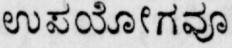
ಉಪಯೋಗವೂ
